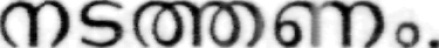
നടത്തണം.
